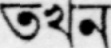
তখন
